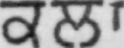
ਕਲਾ
